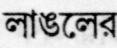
লাঙলের
